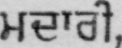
ਮਦਾਰੀ,
